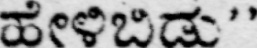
ಹೇಳಿಬಿಡು”
